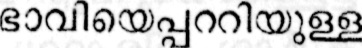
ഭാവിയെപ്പററിയുള്ള
